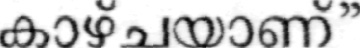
കാഴ്ചയാണ്”
